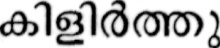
കിളിര്‍ത്തു
